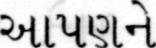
આપણને
